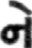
ને
